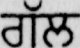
ਗੱਲ
